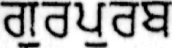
ਗੁਰਪੁਰਬ
